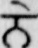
ਨੇ
